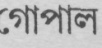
গোপাল
